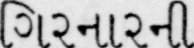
ગિરનારની
